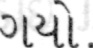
ગયો.
